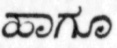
ಹಾಗೂ
